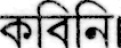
কবিনি।
